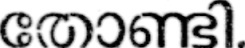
തോണ്ടി.
